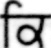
ਕਿ
